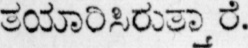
ತಯಾರಿಸಿರುತ್ತಾರೆ.
